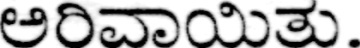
ಅರಿವಾಯಿತು.
